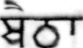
ਬੈਠਾ
